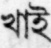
খাই
